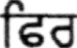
ਫਿਰ
